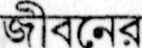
জীবনের
